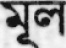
মূল
